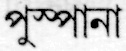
পুস্পানা
